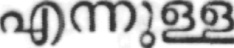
എന്നുള്ള
